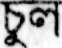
চুল
